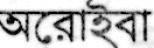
অরোইবা
